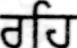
ਰਹਿ
